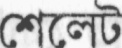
শেলেট
